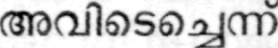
അവിടെച്ചെന്ന്
